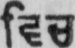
ਵਿਚ
